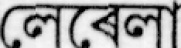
লেৰেলা
